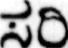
ಸರಿ
